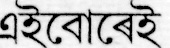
এইবোৰেই
